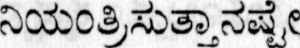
ನಿಯಂತ್ರಿಸುತ್ತಾನಷ್ಟೇ
